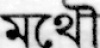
মথৌ
